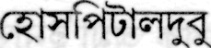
হোসপিটালদুবু
